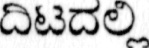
ದಿಟದಲ್ಲಿ
